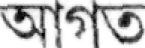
আগত
